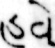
હવે
